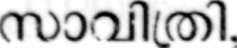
സാവിത്രി,
